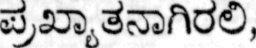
ಪ್ರಖ್ಯಾತನಾಗಿರಲಿ,
